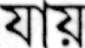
যায়
